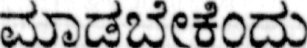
ಮಾಡಬೇಕೆಂದು
